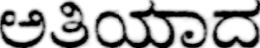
ಅತಿಯಾದ
